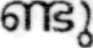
ണ്ടു
